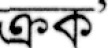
ক্রক’
